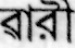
ৱারী
